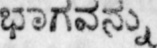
ಭಾಗವನ್ನು
